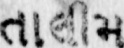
તાલીમ
